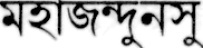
মহাজন্দুনসু
